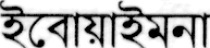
ইবোয়াইমনা
